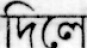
দিলে
